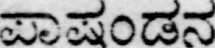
ಪಾಷಂಡನ
